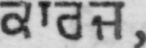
ਕਾਰਜ,
